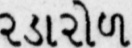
રડારોળ
